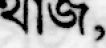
থাজ,
